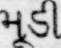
મૂડી
